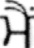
ਮੈਂ
